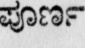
ಪೂರ್ಣ
